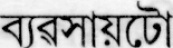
ব্যৱসায়টো
